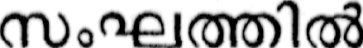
സംഘത്തില്‍
